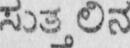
ಸುತ್ತಲಿನ
